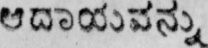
ಆದಾಯವನ್ನು
